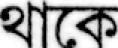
থাকে
